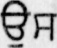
ਉਸ
